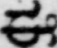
ಈ
